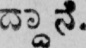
ದ್ದಾನೆ.
